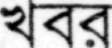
খবর
